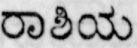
ರಾಶಿಯ
